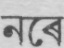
নৰে
